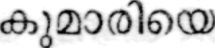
കുമാരിയെ
